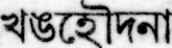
খঙহৌদনা
